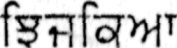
ਝਿਜਕਿਆ
